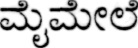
ಮೈಮೇಲೆ
